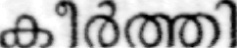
കീര്‍ത്തി
